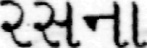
રસના
